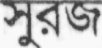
সুরজ
